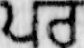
ਪਰ
